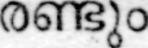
രണ്ടും
